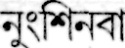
নুংশিনবা
